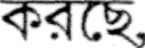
করছে,
